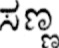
ಸಣ್ಣ
